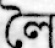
লৈ
